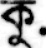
কু.
